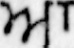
ਆ
